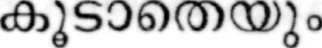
കൂടാതെയും
